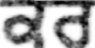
ਕਰ
